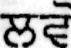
ਲਵੋ
